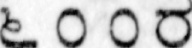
೬೦೦ರ
